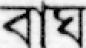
বাঘ
